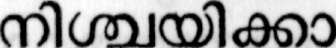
നിശ്ചയിക്കാ
